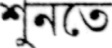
শুনতে
